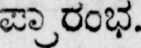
ಪ್ರಾರಂಭ.
